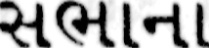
સભાના
